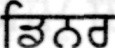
ਡਿਨਰ
